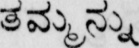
ತಮ್ಮನ್ನು
